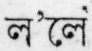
ল'লে
